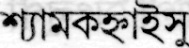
শ্যামকহ্ণাইসু
